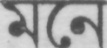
মনে
